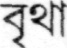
বৃথা
